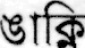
ঙাক্নি
